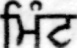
ਮਿੰਟ
